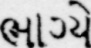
ભાગ્યે
